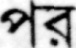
পর
